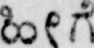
ಹೀಗೆ
